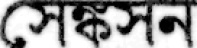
সেঙ্কসন
